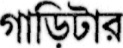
গাড়িটার
